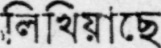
লিখিয়াছে
